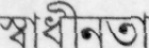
স্বাধীনতা
